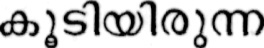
കൂടിയിരുന്ന
